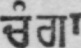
ਚੰਗਾ
